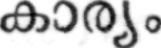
കാര്യം
